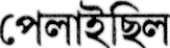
পেলাইছিল
